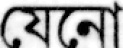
যেনো
